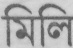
মিলি
